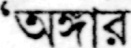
‘অঙ্গার
